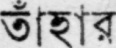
তাঁহার
